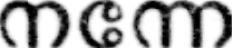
നന്നേ
